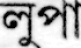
লুপা
